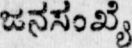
ಜನಸಂಖ್ಯೆ
